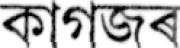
কাগজৰ
